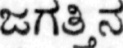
ಜಗತ್ತಿನ
